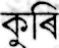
কুৰি
